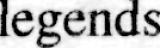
legends
